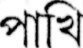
পাখি
